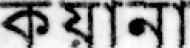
কয়ানা
